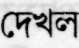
দেখল
